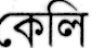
কেলি
